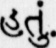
હતું.
